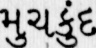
મુચકુંદ
